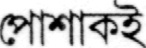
পোশাকই
